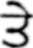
ਤੇ
